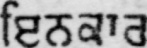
ਇਨਕਾਰ
